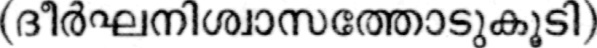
(ദീര്‍ഘനിശ്വാസത്തോടുകൂടി)
